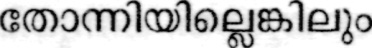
തോന്നിയില്ലെങ്കിലും
